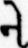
ને
